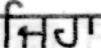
ਜਿਹਾ
